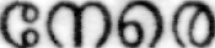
നേരെ
